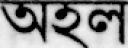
অহল
